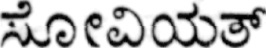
ಸೋವಿಯತ್
